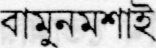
বামুনমশাই
